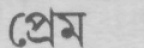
প্ৰেম
